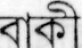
বাকী
